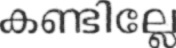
കണ്ടില്ലേ
